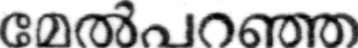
മേല്‍പറഞ്ഞ
